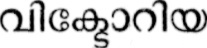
വിക്ടോറിയ
